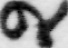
જ
